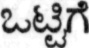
ಒಟ್ಟಿಗೆ
